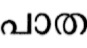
പാത
